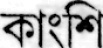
কাংশি
